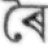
ৰৈ
